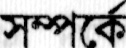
সম্পর্কে
